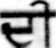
ਦੀ
